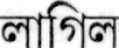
লাগিল
